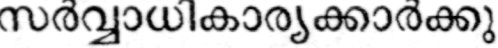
സര്‍വ്വാധികാര്യക്കാര്‍ക്കു
